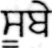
ਸੂਬੇ
